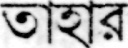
তাহার
